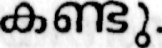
കണ്ടു.
